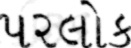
પરલોક
